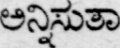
ಅನ್ನಿಸುತಾ
